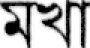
মখা
